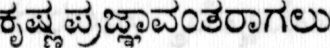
ಕೃಷ್ಣಪ್ರಜ್ಞಾವಂತರಾಗಲು
